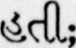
હતી;
